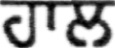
ਹਾਲ
